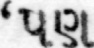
'પણ
